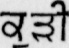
ਕੁੜੀ
